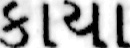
કાયા
